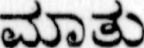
ಮಾತು
